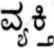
ವ್ಯಕ್ತಿ
